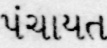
પંચાયત
